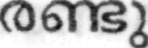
രണ്ടു
